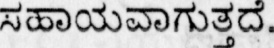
ಸಹಾಯವಾಗುತ್ತದೆ.
